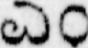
ಎಂ
